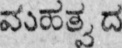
ಮಹತ್ವದ
